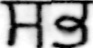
ਸਭ
